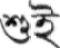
শুই
